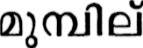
മുമ്പില്
